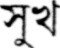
সুখ
